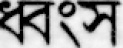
ধ্বংস
